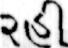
રહી
